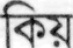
কিয়
